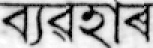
ব্যৱহাৰ
